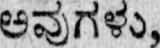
ಅವುಗಳು,
